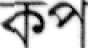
কপ
